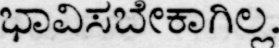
ಭಾವಿಸಬೇಕಾಗಿಲ್ಲ.
